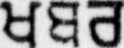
ਖਬਰ
